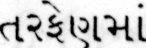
તરફેણમાં
